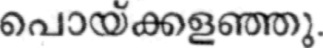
പൊയ്ക്കളഞ്ഞു.
